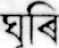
ঘুৰি
